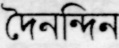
দৈনন্দিন
